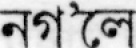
নগ'লে
